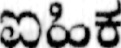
ಐಹಿಕ
